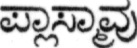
ಪ್ಲಾಸ್ಮಾವು
